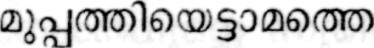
മുപ്പത്തിയെട്ടാമത്തെ
